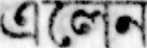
এলেন
